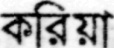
করিয়া
